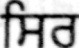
ਸਿਰ
